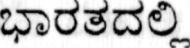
ಭಾರತದಲ್ಲಿ
